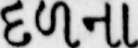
દળના
